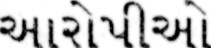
આરોપીઓ
